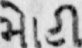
મોટી
